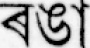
ৰঙা
